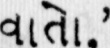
વાતો.'
